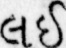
લઈ
